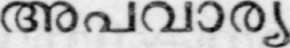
അപവാര്യ
